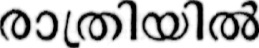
രാത്രിയില്‍
